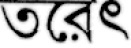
তরেৎ
